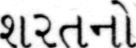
શરતનો
